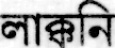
লাক্কনি
